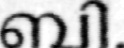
ബി.
